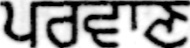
ਪਰਵਾਣ
